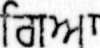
ਗਿਆ
